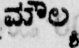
ಮೌಲ್ಯ
